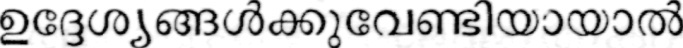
ഉദ്ദേശ്യങ്ങള്‍ക്കുവേണ്ടിയായാല്‍
